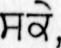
ਸਕੇ,
